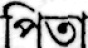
পিতা
